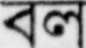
বল
